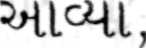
આવ્યા,
